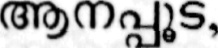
ആനപ്പൂട,
